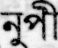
নুপী
